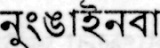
নুংঙাইনবা
